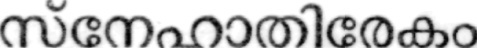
സ്നേഹാതിരേകം
